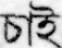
চাই
